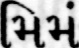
મિમં
